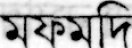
মফমদি
